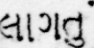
લાગતું
